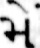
મેં
